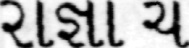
રાજ્ઞાચ
